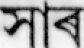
সাৰ
